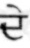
ਦੇ
